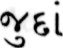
જુદાં
